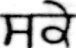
ਸਕੇ
